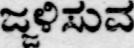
ಜ್ಜಳಿಸುವ
